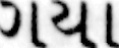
ગયા
